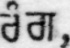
ਰੰਗ,
